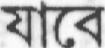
যাবে
